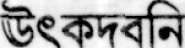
ঊৎকদবনি
